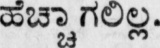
ಹೆಚ್ಚಾಗಲಿಲ್ಲ.
